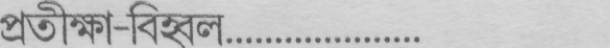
প্ৰতীক্ষা-বিহ্বল......................
